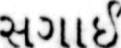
સગાઈ
